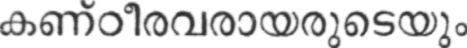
കണ്ഠീരവരായരുടെയും
